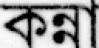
কন্না
